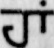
ਹਾਂ
